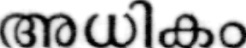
അധികം
